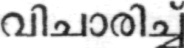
വിചാരിച്ച്
